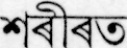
শৰীৰত
